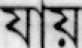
যায়
